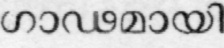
ഗാഢമായി
